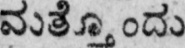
ಮತ್ತೊಂದು
